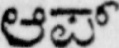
ಆಪ್
